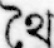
থৈ
